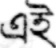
এই
